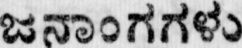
ಜನಾಂಗಗಳು
